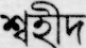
শ্বহীদ
